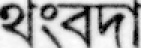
থংবদা
